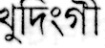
খুদিংগী
